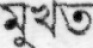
মুখত
